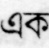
এক
